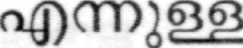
എന്നുള്ള
